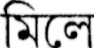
মিলে
